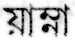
য়াম্না
